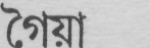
গৈয়া
